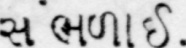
સંભળાઈ.
